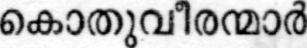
കൊതുവീരന്മാര്‍
